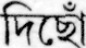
দিছোঁ
